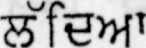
ਲੱਦਿਆ
